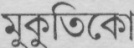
মুকুতিকো
